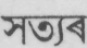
সত্যৰ
